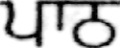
ਪਾਠ
